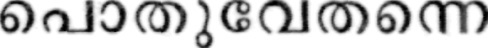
പൊതുവേതന്നെ
